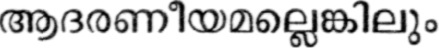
ആദരണീയമല്ലെങ്കിലും
